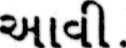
આવી.
